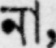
না,
